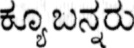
ಕ್ಯೂಬನ್ನರು
